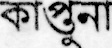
কাপ্তুনা
